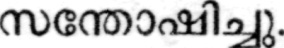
സന്തോഷിച്ചു.
